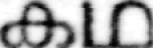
കഥ
